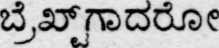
ಬ್ರೆಖ್ಟ್‌ಗಾದರೋ
